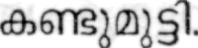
കണ്ടുമുട്ടി.
